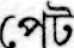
পেট
